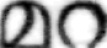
മറ
